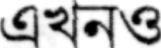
এখনও
